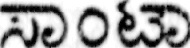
ಸಾಂಟಾ
